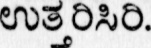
ಉತ್ತರಿಸಿರಿ.
